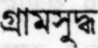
গ্রামসুদ্ধ
